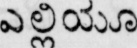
ಎಲ್ಲಿಯೂ
